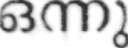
ഒന്നു
